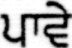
ਪਾਵੇ
